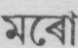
মৰো
